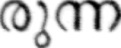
രുന്ന
